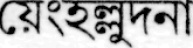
য়েংহল্লুদনা
